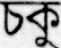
চকু
